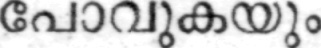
പോവുകയും
